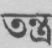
তন্ত্র
